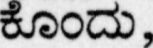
ಕೊಂದು,
